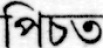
পিচত
